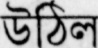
উঠিল
